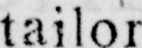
tailor
